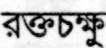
রক্তচক্ষু
